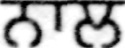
ਨਾਲ
